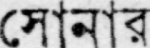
সোনার
